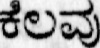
ಕೆಲವು
